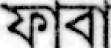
ফাবা
